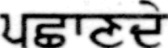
ਪਛਾਣਦੇ
